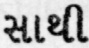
સાથી
